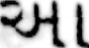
આ
